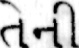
તેની
